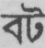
বট
